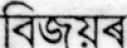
বিজয়ৰ
